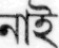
নাই
